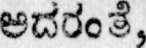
ಅದರಂತೆ,
